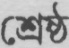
শ্ৰেষ্ঠ
